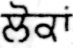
ਲੋਕਾਂ
